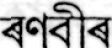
ৰণবীৰ
